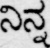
ನಿನ್ನ
